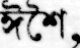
ঈশৈ,
